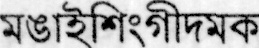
মঙাইশিংগীদমক
